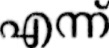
എന്ന്
